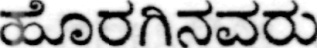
ಹೊರಗಿನವರು
